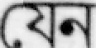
যেন
